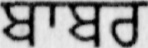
ਬਾਬਰ
